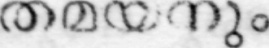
തമയനും
